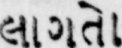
લાગતો
